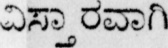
ವಿಸ್ತಾರವಾಗಿ
